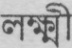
লক্ষ্মী
